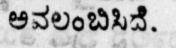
ಅವಲಂಬಿಸಿದೆ.
